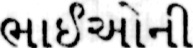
ભાઈઓની
